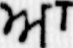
ਆ
